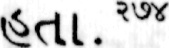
હતા.૨૭૪
